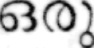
ഒരു
